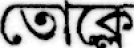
তোক্লে
